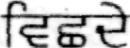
ਵਿਛਦੇ
